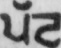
ਪੱਟ
